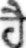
ਹੈ
